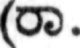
(ರಾ.
